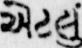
એટલું
